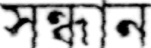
সন্ধান
